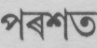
পৰশত
